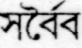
সর্বৈব
